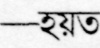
–হয়ত
